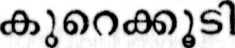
കുറെക്കൂടി
